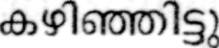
കഴിഞ്ഞിട്ടു
